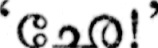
'ഛേ!'
